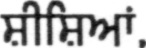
ਸ਼ੀਸ਼ਿਆਂ,
